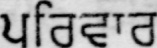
ਪਰਿਵਾਰ
